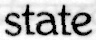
state
